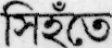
সিহঁতে
